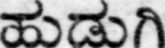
ಹುಡುಗಿ
